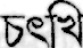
চৎখি
